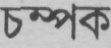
চম্পক
